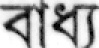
বাধ্য
